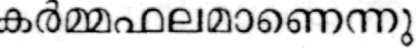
കര്‍മ്മഫലമാണെന്നു
